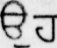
ਉਹ
